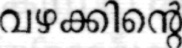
വഴക്കിന്റെ
